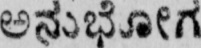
ಅನುಭೋಗ
